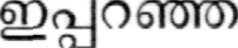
ഇപ്പറഞ്ഞ
